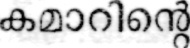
കമാറിന്റെ
